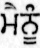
ਮੈਨੂੰ
